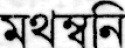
মথম্বনি
